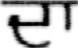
ਦਾ
